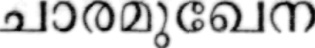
ചാരമുഖേന
